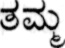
ತಮ್ಮ
